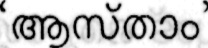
'ആസ്താം'
